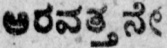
ಅರವತ್ತನೇ
